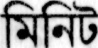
মিনিট
